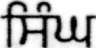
ਸਿੰਘ
